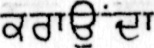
ਕਰਾਉਂਦਾ
